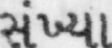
સંખ્યા
